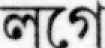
লগে
